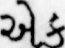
એક
